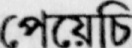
পেয়েচি
